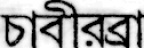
চাবীরব্রা
